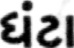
ધંટા
